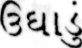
ઉઘાડું
